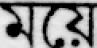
ময়ে
